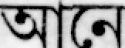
আনে
